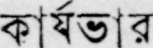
কার্যভার
